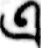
এ
